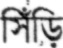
সিঁড়ি
